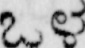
ಒಳ
